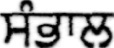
ਸੰਭਾਲ
